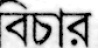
বিচার
